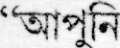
"আপুনি
